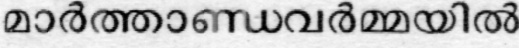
മാര്‍ത്താണ്ഡവര്‍മ്മയില്‍
